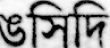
ঙসিদি
